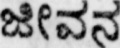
ಜೀವನ
